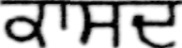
ਕਾਸਦ
